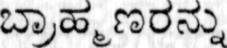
ಬ್ರಾಹ್ಮಣರನ್ನು
